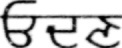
ਓਦਣ
